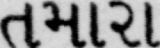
તમારા
